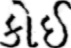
કોઈ
